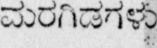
ಮರಗಿಡಗಳು
